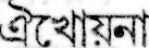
ঐখোয়না
